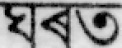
ঘৰত
